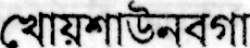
খোয়শাউনবগা
